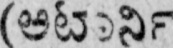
(ಅಟಾರ್ನಿ
